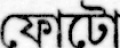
ফোটো
